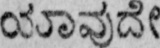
ಯಾವುದೇ
